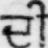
ਦੀ
